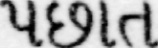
પછાત
